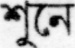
শুনে
